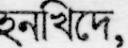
হনখিদে,
